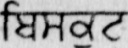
ਬਿਸਕੁਟ
